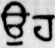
ਉਹ
